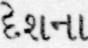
દેશના
